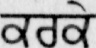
ਕਰਕੇ
